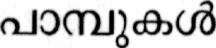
പാമ്പുകള്‍
